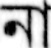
না
